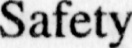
Safety
